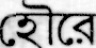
হৌরে
